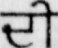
ਦੀ
